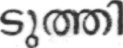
ടുത്തി
